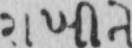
રાખીને
